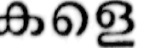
കളെ
